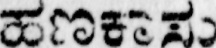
ಹಣಕಾಸು
